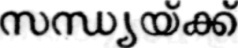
സന്ധ്യയ്ക്ക്
